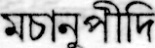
মচানুপীদি
